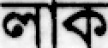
লাক
